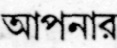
আপনার
